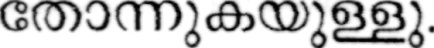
തോന്നുകയുള്ളു.
